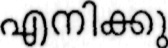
എനിക്കു
